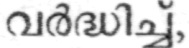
വര്‍ദ്ധിച്ച്,
